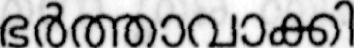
ഭര്‍ത്താവാക്കി
